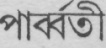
পাৰ্ব্বতী
